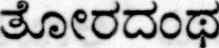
ತೋರದಂಥ
